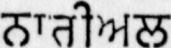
ਨਾਰੀਅਲ
